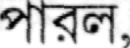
পারল,
